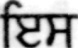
ਇਸ
